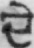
ਦੇ
